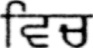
ਵਿਚ
